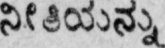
ನೀತಿಯನ್ನು
